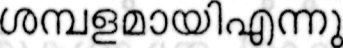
ശമ്പളമായിഎന്നു
